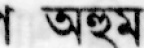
অহুম
